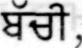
ਬੱਚੀ,
